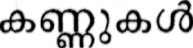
കണ്ണുകള്‍
